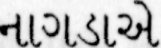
નાગડાએ
